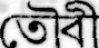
তৌবী
